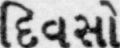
દિવસો
